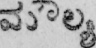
ಮೌಲ್ಯ
